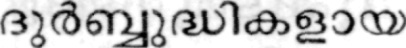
ദുര്‍ബുദ്ധികളായ
